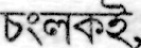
চংলকই,
